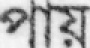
পায়
